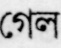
গেল
